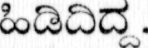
ಹಿಡಿದಿದ್ದ.
